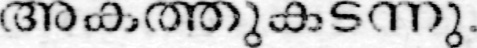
അകത്തുകടന്നു.
